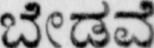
ಬೇಡವೆ
